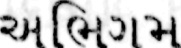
અભિગમ
